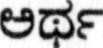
ಅರ್ಥ
